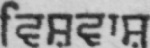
ਵਿਸ਼ਵਾਸ਼
